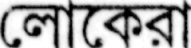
লোকেরা
